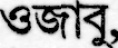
ওজাবু,
